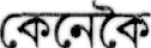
কেনেকৈ
